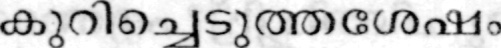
കുറിച്ചെടുത്തശേഷം
